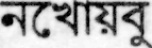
নখোয়বু
